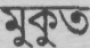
মুকুত
